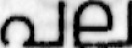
പല
